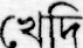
খেদি
